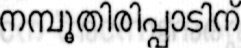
നമ്പൂതിരിപ്പാടിന്
